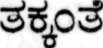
ತಕ್ಕಂತೆ
